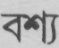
বশ্য
